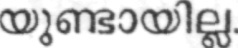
യുണ്ടായില്ല.
